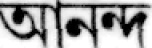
আনন্দ
